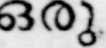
ഒരു.
